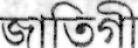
জাতিগী
